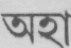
অহা
